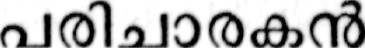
പരിചാരകന്‍
